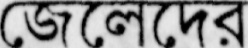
জেলেদের
